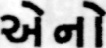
એનો
